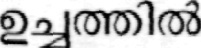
ഉച്ചത്തില്‍
